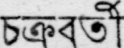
চক্রবর্তী
